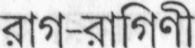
রাগ-রাগিণী
